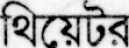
থিয়েটর
